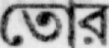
তোর
